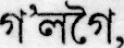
গ'লগৈ,
